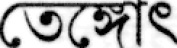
তেঙ্গোৎ
